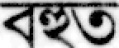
বহুত
